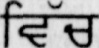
ਵਿੱਚ
